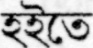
হইতে
